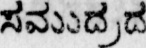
ಸಮುದ್ರದ
